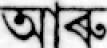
আৰু
